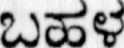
ಬಹಳ
